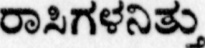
ರಾಸಿಗಳನಿತ್ತು
